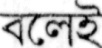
বলেই
